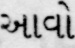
આવો
